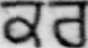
ਕਰ
